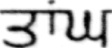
ਤਾਂਘ
